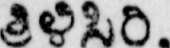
ತಿಳಿಸಿರಿ.
